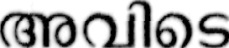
അവിടെ
